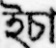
ইচা
